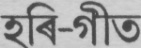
হৰি-গীত
